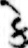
કે
